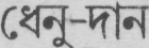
ধেনু-দান
